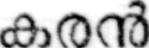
കരന്‍
